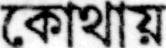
কোথায়
